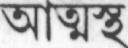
আত্মস্থ
